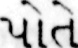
પોતે
